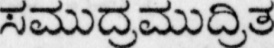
ಸಮುದ್ರಮುದ್ರಿತ
